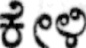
ಕೇಳಿ
